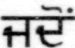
ਜਦੋਂ
